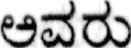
ಅವರು
